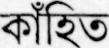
কাঁহিত
